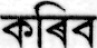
কৰিব
